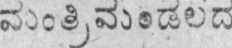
ಮಂತ್ರಿಮಂಡಲದ
